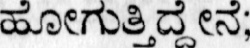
ಹೋಗುತ್ತಿದ್ದೇನೆ;
